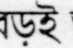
বড়ই
